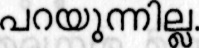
പറയുന്നില്ല.
